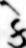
કે
